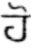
ਹੋ
